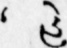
'હે
